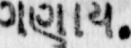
ગણાય.
